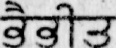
ਭੈਭੀਤ
